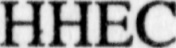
HHEC
